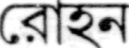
রোহন
